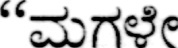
"ಮಗಳೇ
